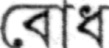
বোধ
